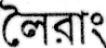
লৈরাং
